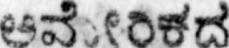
ಅಮೇರಿಕದ
